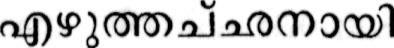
എഴുത്തച്ഛനായി
